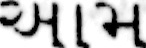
આમ
